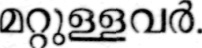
മറ്റുള്ളവര്‍.
